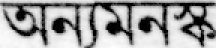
অন্যমনস্ক
